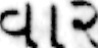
વાર
